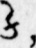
કે,
